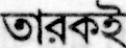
তারকই
